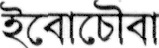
ইবোচৌবা
